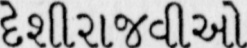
દેશીરાજવીઓ
